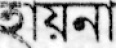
হায়না
